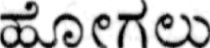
ಹೋಗಲು
